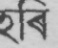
হৰি
